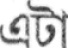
এটা
